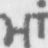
ਮਾਂ
